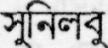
সুনিলবু
